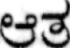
ಆತ
